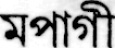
মপাগী
